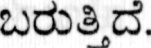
ಬರುತ್ತಿದೆ.
